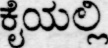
ಕೈಯಲ್ಲಿ
